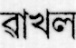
ৱাখল
